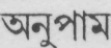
অনুপাম
